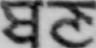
ਬਣ
